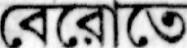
বেরোতে
